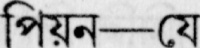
পিয়ন-যে
